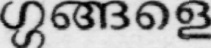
ഗ്ഗങ്ങളെ
